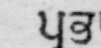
ਪ੍ਭਾ
